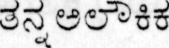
ತನ್ನಅಲೌಕಿಕ
